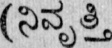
(ನಿವೃತ್ತಿ
